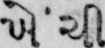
ખેંચી
